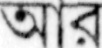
আর
